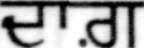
ਦਾਗ਼
